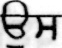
ਉਸ
